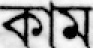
কাম
